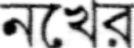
নখের
